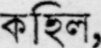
কহিল,
